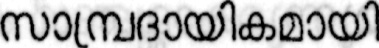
സാമ്പ്രദായികമായി
